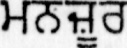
ਮਨਜ਼ੂਰ
